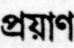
প্রয়াণ
